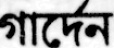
গার্দেন
